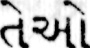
તેઓ
